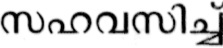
സഹവസിച്ച്
